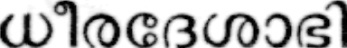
ധീരദേശാഭി
